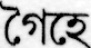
গৈহে
